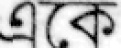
একে
